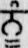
ਨੂੰ
